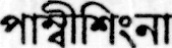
পাম্বীশিংনা
